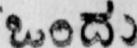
ಒಂದು
